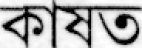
কাষত
